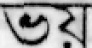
ভয়
